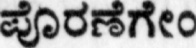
ಪೊರಣೆಗೇಂ
